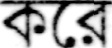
করে
